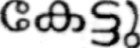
കേട്ടു
